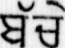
ਬੱਚੇ
